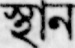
স্থান
